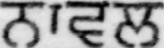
ਨਾਵਲ
